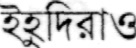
ইহুদিরাও
